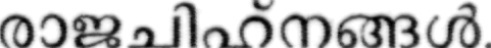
രാജചിഹ്നങ്ങള്‍.
